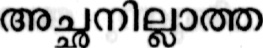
അച്ഛനില്ലാത്ത
